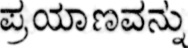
ಪ್ರಯಾಣವನ್ನು
